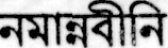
নমান্নবীনি
